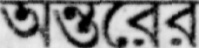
অন্তরের
